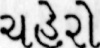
ચહેરો
